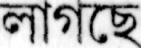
লাগছে
